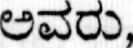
ಅವರು,
